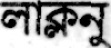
লাক্লনু
